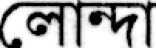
লোন্দা
